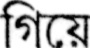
গিয়ে
